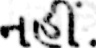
નહીં.
